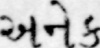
અનેક
